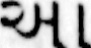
આ
